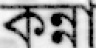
কন্না
